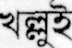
খল্লুই
